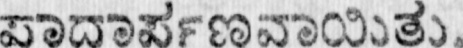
ಪಾದಾರ್ಪಣವಾಯಿತು.
